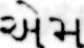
એમ
